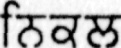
ਨਿਕਲ
